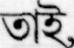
তাই,
